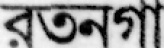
রতনগা
